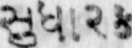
સુધારક
